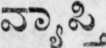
ವ್ಯಾಪ್ತಿ
